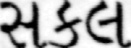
સકલ
